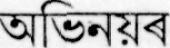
অভিনয়ৰ
